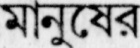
মানুষের
